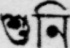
শুনি
